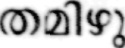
തമിഴു
